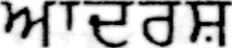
ਆਦਰਸ਼
